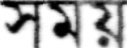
সময়
